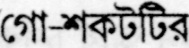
গো-শকটটির
